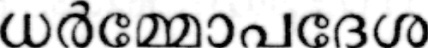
ധര്‍മ്മോപദേശ
